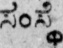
ಸಂಸ್ಥೆ
